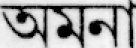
অমনা
